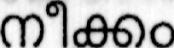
നീക്കം
